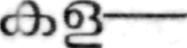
കള-
